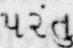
પરંતુ
